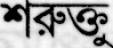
শরুক্তু
